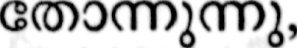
തോന്നുന്നു,
